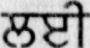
ਲਈ
